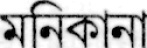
মনিকানা
